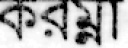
করম্না
